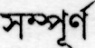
সম্পূর্ণ
